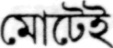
মোটেই
